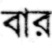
বার
